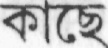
কাছে
